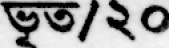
ভুত/২০
